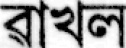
ৱাখল
